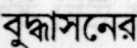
বুদ্ধাসনের
